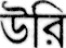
উরি
